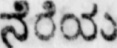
ನೆರೆಯ
